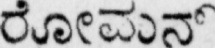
ರೋಮನ್
